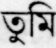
তুমি
